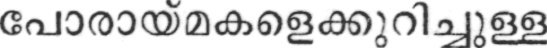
പോരായ്മകളെക്കുറിച്ചുള്ള
